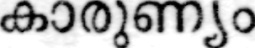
കാരുണ്യം
